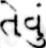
તેવું
